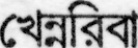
খেন্নরিবা
